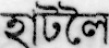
হাটলৈ
